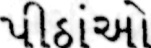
પીઠાંઓ
